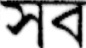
সব
